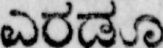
ಎರಡೂ
